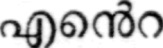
എന്റെ
